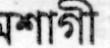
মশাগী
